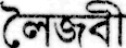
লৈজবী
